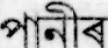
পানীৰ
